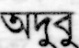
অদুদু
